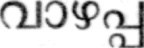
വാഴപ്പ
